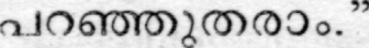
പറഞ്ഞുതരാം."
